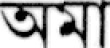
অম
